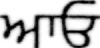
ਆਓ
